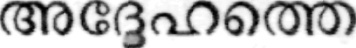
അദ്ദേഹത്തെ
